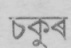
চকুৰ
